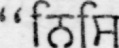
''ਨਿਸਿ
